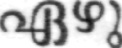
ഏഴു
